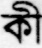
কী
